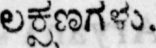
ಲಕ್ಷಣಗಳು.
